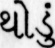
થોડું
